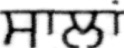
ਸਾਲਾਂ
